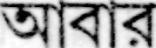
আবার
